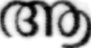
ആ
